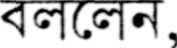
বললেন,
